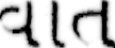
વાત
